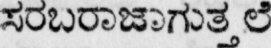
ಸರಬರಾಜಾಗುತ್ತಲೆ
